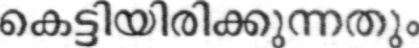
കെട്ടിയിരിക്കുന്നതും
